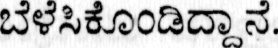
ಬೆಳೆಸಿಕೊಂಡಿದ್ದಾನೆ.
